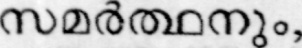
സമര്‍ത്ഥനും,
